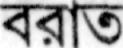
বরাত
